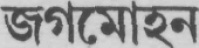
জগমোহন
